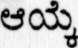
ಆಯ್ಕೆ
